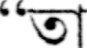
“তা
